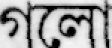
গলো
